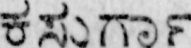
ಕಸುರ್ಗಾ
